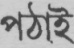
পঠাই
